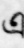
এ
